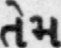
તેમ
